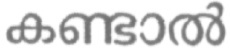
കണ്ടാല്‍
